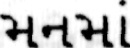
મનમાં
